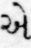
એ
